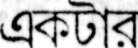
একটার
